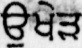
ਉਖੇੜ
